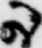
જે
